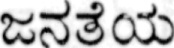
ಜನತೆಯ
